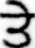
ਤੇ
